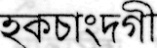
হকচাংদগী
